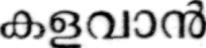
കളവാന്‍
